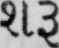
શરૂ
